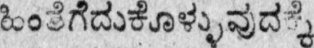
ಹಿಂತೆಗೆದುಕೊಳ್ಳುವುದಕ್ಕೆ
